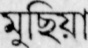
মুছিয়া
